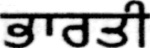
ਭਾਰਤੀ
